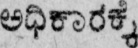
ಅಧಿಕಾರಕ್ಕೆ
